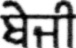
ਬੇਜੀ
